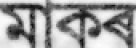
মাকৰ
